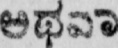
ಅಥವಾ
